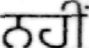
ਨਹੀਂ
